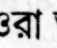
ওরা
